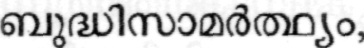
ബുദ്ധിസാമര്‍ത്ഥ്യം,
